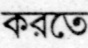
করতে
